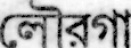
লৌরগা
